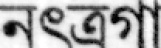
নৎত্রগা
